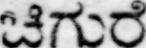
ಚಿಗುರೆ
